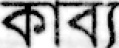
কাব্য
